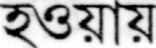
হওয়ায়
